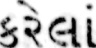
કરેલાં
